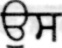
ਉਸ
